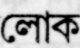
লোক
